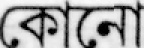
কোনো
